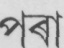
পৰা
